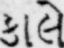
કાલે
